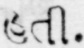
હતી.
